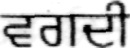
ਵਗਦੀ
